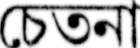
চেতনা
